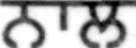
ਨਾਲ
